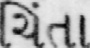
ચિંતા
